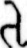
તે
